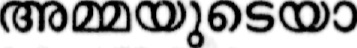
അമ്മയുടെയാ
